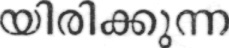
യിരിക്കുന്ന
